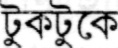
টুকটুকে
